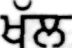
ਖੱਲ
